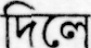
দিলে
